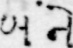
બંને
